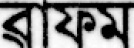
ৱাফম
